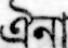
ঐনা
